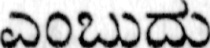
ಎಂಬುದು
